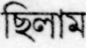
ছিলাম
